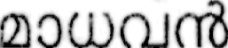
മാധവന്‍
